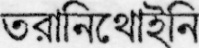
তরানিথোইনি
